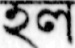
হল
